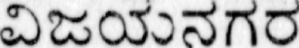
ವಿಜಯನಗರ
